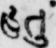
હતું
